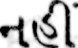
નહીં
